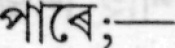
পাৰে;-
